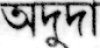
অদুদা
